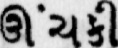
ઊંચકી
